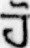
ਹੋ
